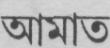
আমাত
